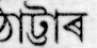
ঠাট্টাৰ
